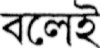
বলেই
